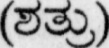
(ಶತ್ರು)
